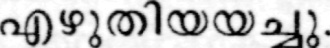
എഴുതിയയച്ചു.
